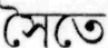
সৈতে
